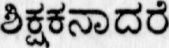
ಶಿಕ್ಷಕನಾದರೆ
